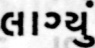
લાગ્યું
